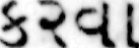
કરવા
